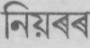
নিয়ৰৰ
